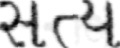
સત્ય
